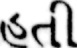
હતી
